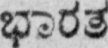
ಭಾರತ
